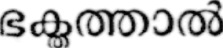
ഭക്തത്താല്‍
